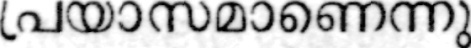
പ്രയാസമാണെന്നു
